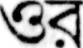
ওর
